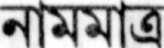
নামমাত্র
